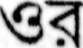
ওর
